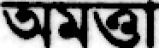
অমত্তা
